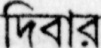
দিবার
